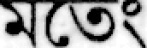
মতেং
